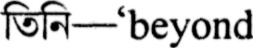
তিনি-'beyond
